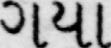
ગયા
